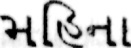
મહિના
